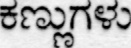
ಕಣ್ಣುಗಳು
